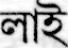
লাই
